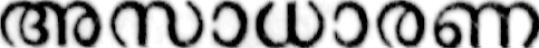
അസാധാരണ
